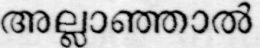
അല്ലാഞ്ഞാല്‍
